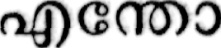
എന്തോ
